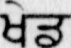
ਖੇਡ
